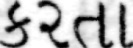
કરતા
